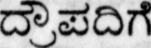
ದ್ರೌಪದಿಗೆ
